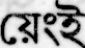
য়েংই
